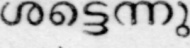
ശട്ടെന്നു
